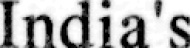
India's
